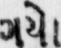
ગયો
